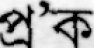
প্র'ক
